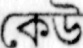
কেউ
